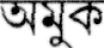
অমুক
